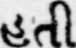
હતી
